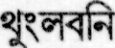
থুংলবনি
